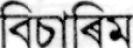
বিচাৰিম
